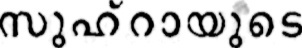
സുഹ്റായുടെ
